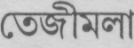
তেজীমলা
